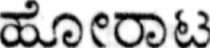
ಹೋರಾಟ
